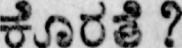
ಕೊರತೆ?
